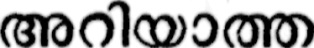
അറിയാത്ത
